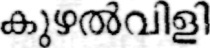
കുഴല്‍വിളി
